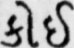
કોઈ
